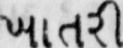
ખાતરી
